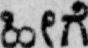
ಹೀಗೆ
